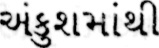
અંકુશમાંથી
